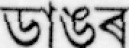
ডাঙৰ
